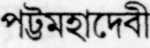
পট্টমহাদেবী
